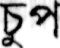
চুপ
